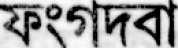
ফংগদবা
